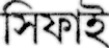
সিফাই
